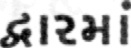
દ્વારમાં
